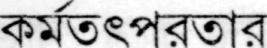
কর্মতৎপরতার
